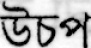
উচপ
